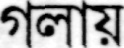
গলায়
